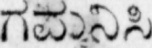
ಗಮನಿಸಿ
